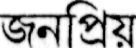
জনপ্রিয়
